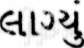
લાગ્યું
